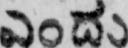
ಎಂದು
